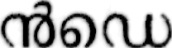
ന്‍ഡെ
